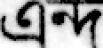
এন্দ
